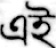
এই
